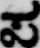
ಪ
